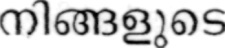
നിങ്ങളുടെ
